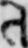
તે
